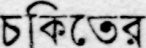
চকিতের
